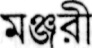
মঞ্জরী
